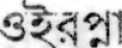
ওইরপ্না
